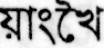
য়াংখৈ
